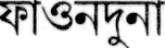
ফাওনদুনা
